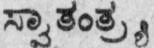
ಸ್ವಾತಂತ್ರ್ಯ
